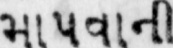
માપવાની
